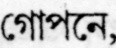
গোপনে,
